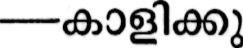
-കാളിക്കു
